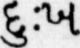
દુઃખ
